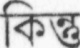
কিন্তু
